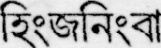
হিংজনিংবা
